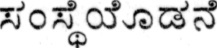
ಸಂಸ್ಥೆಯೊಡನೆ
